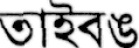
তাইবঙ
